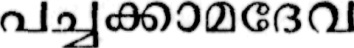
പച്ചക്കാമദേവ
